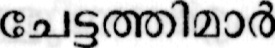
ചേട്ടത്തിമാര്‍
